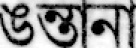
ঙন্তানা
